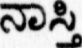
ನಾಸ್ತಿ
